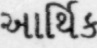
આર્થિક
